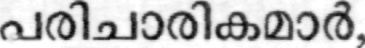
പരിചാരികമാര്‍,
